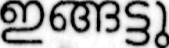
ഇങ്ങട്ടു
